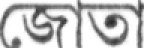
জোতা
